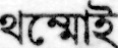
থম্মোই
